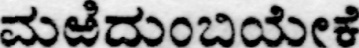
ಮಱಿದುಂಬಿಯೇಕೆ
